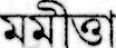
মমীত্তা
